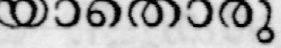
യാതൊരു
